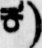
ಕ)
